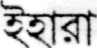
ইহারা
